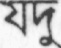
যদু
